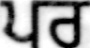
ਪਰ
